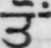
ਤੋਂ
